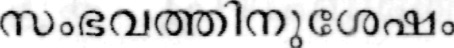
സംഭവത്തിനുശേഷം
